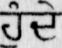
ਹੁੰਦੇ
